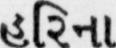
હરિના
